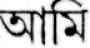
আমি
